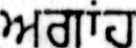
ਅਗਾਂਹ
